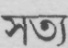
সত্য
